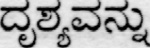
ದೃಶ್ಯವನ್ನು
